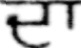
ਦਾ
